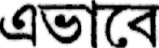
এভাবে
